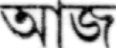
আজ
